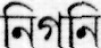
নিগনি
